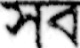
সব
